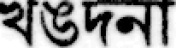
খঙদনা
